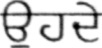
ਉਹਦੇ
